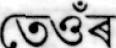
তেওঁৰ
